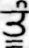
ਤੂੰ
